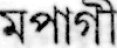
মপাগী
